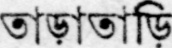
তাড়াতাড়ি
